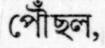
পৌঁছল,
